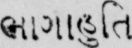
ભાગાહુતિ
